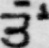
ਤੋਂ
